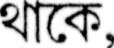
থাকে,
